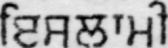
ਇਸਲਾਮੀ
